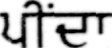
ਪੀਂਦਾ
